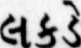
લકડે
